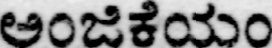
ಅಂಜಿಕೆಯಂ
